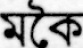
মকৈ
